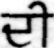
ਦੀ
